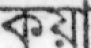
কয়া
